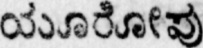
ಯೂರೋಪು
